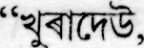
"খুৰাদেউ,
